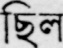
ছিল
